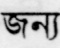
জন্য
